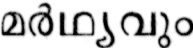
മര്‍ഥ്യവും
